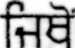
ਜਿਥੋਂ
